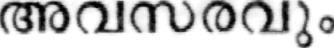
അവസരവും
